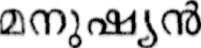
മനുഷ്യന്‍
